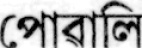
পোৱালি
